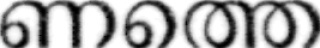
ണത്തെ
